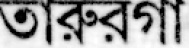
তারুরগা
